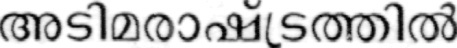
അടിമരാഷ്ട്രത്തില്‍
